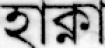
হাক্না
